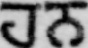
ਹਨ
